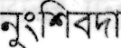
নুংশিবদা
